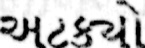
અટક્યો
